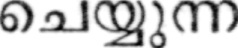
ചെയ്യുന്ന
